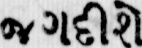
જગદીશે
